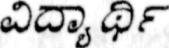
ವಿದ್ಯಾರ್ಥಿ
